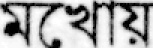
মখোয়
